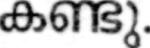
കണ്ടു.
